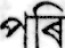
পৰি
